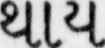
થાય
